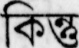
কিন্তু
